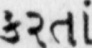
કરતાં
